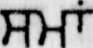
ਸਮਾਂ
